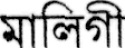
মালিগী
